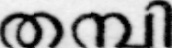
തമ്പി
